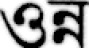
ওন্ন
